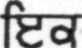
ਇਕ
